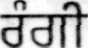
ਰੰਗੀ
